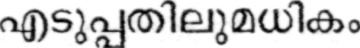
എടുപ്പതിലുമധികം
